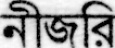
নীজরি
